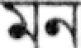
মন
